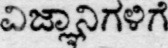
ವಿಜ್ಞಾನಿಗಳಿಗೆ
